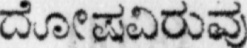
ದೋಷವಿರುವು
